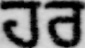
ਹਰ
